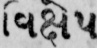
વિક્ષેપ
